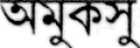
অমুকসু
